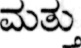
ಮತ್ತು
